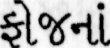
ફોજનાં
